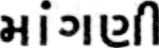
માંગણી
